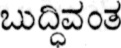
ಬುದ್ಧಿವಂತ
